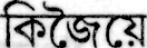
কিজৈয়ে
